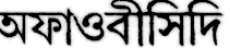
অফাওবীসিদি
